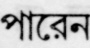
পারেন
